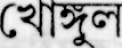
খোঙ্গুল
